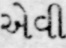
એવી
